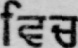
ਵਿਚ
